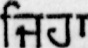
ਜਿਹਾ
